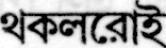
থকলরোই
